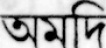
অমদি
